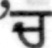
'ਚ
